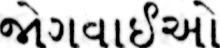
જોગવાઈઓ
